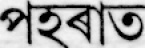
পহৰাত
